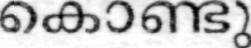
കൊണ്ടു
